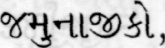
જમુનાજીકે,
